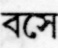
বসে
